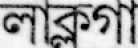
লাক্লগা
